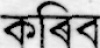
কৰিব
